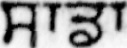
ਸਾਡਾ
